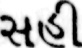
સહી
